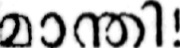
മാന്തി!
